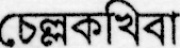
চেল্লকখিবা
